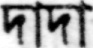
দাদা
